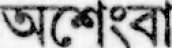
অশেংবা
